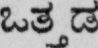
ಒತ್ತಡ
